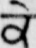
ਕੇ
